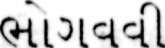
ભોગવવી
